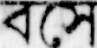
বসে
